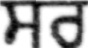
ਸਰ
